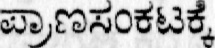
ಪ್ರಾಣಸಂಕಟಕ್ಕೆ
